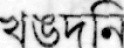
খঙদনি
